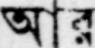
আর
